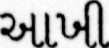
આખી
